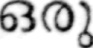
ഒരു
